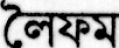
লৈফম
